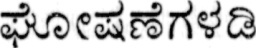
ಘೋಷಣೆಗಳಡಿ
